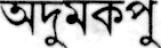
অদুমকপু
